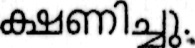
ക്ഷണിച്ചു.
